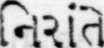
નિરાંતે
